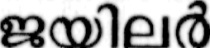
ജയിലര്‍
